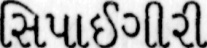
સિપાઈગીરી
